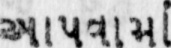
આપવામાં
